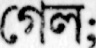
গেল;
